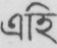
এহি
